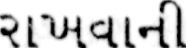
રાખવાની
